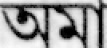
অমা
